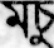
মচু
